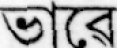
ভাৱে
